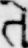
તે
